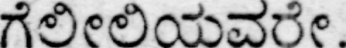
ಗೆಲೀಲಿಯವರೇ.
